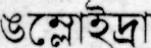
ঙম্লোইদ্রা
